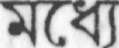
মধ্যে
